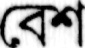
বেশ
